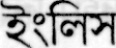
ইংলিস
